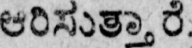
ಆರಿಸುತ್ತಾರೆ.
